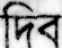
দিব
